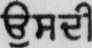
ਉਸਦੀ
